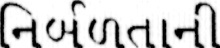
નિર્બળતાની
